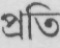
প্ৰতি
